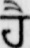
ਹੈ
